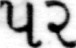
પર
